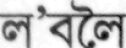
ল'বলৈ
